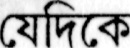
যেদিকে
